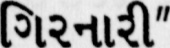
ગિરનારી
